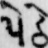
પેઠે
